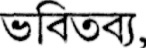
ভবিতব্য,
